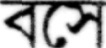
বসে
